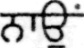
ਨਾਉਂ
